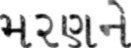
મરણને
